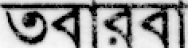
তবারবা
